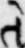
તે
